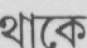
থাকে
